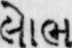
લોભ
